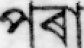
পৰা
